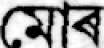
মোৰ
